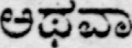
ಅಥವಾ
